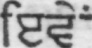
ਇਵੇਂ
